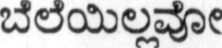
ಬೆಲೆಯಿಲ್ಲವೋ
